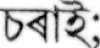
চৰাই;
